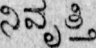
ನಿವೃತ್ತಿ
